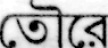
তৌরে
